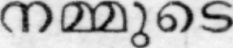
നമ്മുടെ
